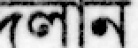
দলান
